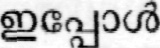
ഇപ്പോള്‍
